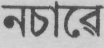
নচাৱে
